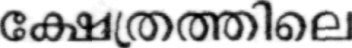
ക്ഷേത്രത്തിലെ
